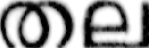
തല
